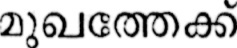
മുഖത്തേക്ക്
